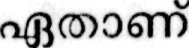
ഏതാണ്
